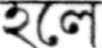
হলে
